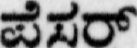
ಪೆಸರ್
